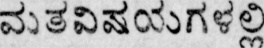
ಮತವಿಷಯಗಳಲ್ಲಿ
